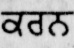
ਕਰਨ
